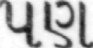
પણ
